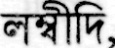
লম্বীদি,
